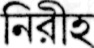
নিরীহ
